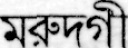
মরুদগী
